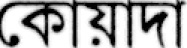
কোয়াদা
